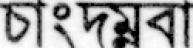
চাংদম্নবা
